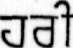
ਹਰੀ
